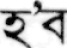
হ'ব
